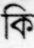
কি
